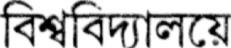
বিশ্ববিদ্যালয়ে
